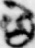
છે
